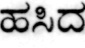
ಹಸಿದ
